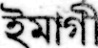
ইমাগী
